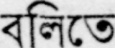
বলিতে
